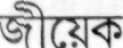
জীয়েক
